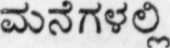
ಮನೆಗಳಲ್ಲಿ
